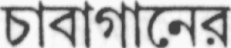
চাবাগানের
